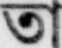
তা
